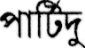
পার্টিদু
